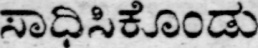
ಸಾಧಿಸಿಕೊಂಡು
